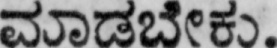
ಮಾಡಬೇಕು.
